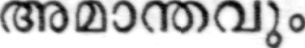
അമാന്തവും
